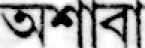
অশাবা
